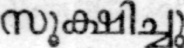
സൂക്ഷിച്ചു
